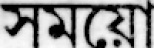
সময়ো
